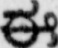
ಈ
